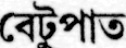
বেটুপাত
